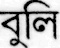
বুলি
